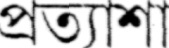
প্রত্যাশা
